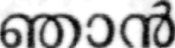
ഞാന്‍
